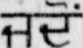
ਜਦੋਂ
